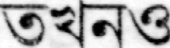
তখনও
